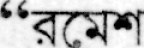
“রমেশ
